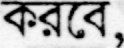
করবে,
